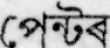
পেন্টৰ
